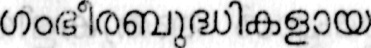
ഗംഭീരബുദ്ധികളായ
